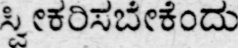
ಸ್ವೀಕರಿಸಬೇಕೆಂದು
